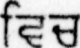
ਵਿਚ
